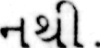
નથી.
